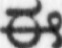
ಈ
